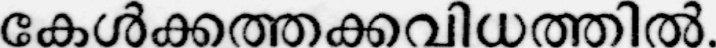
കേള്‍ക്കത്തക്കവിധത്തില്‍,
